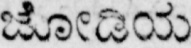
ಜೋಡಿಯ
